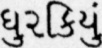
ધુરકિયું
